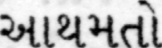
આથમતો
